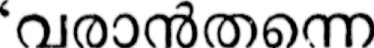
‘വരാന്‍തന്നെ
